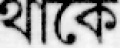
থাকে
